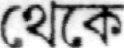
থেকে
